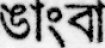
ঙাংবা
